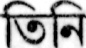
তিনি
